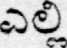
ಎಲ್ಲಿ
